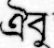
ঐবু
